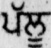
ਪੱਲੂ
